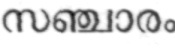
സഞ്ചാരം
